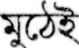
মুঠেই
